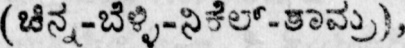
(ಚಿನ್ನ-ಬೆಳ್ಳಿ-ನಿಕೆಲ್-ತಾಮ್ರ),
